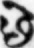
છે
